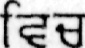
ਵਿਚ
